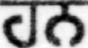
ਹਨ
